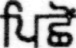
ਪਿਛੋਂ
